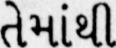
તેમાંથી
